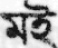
মই
